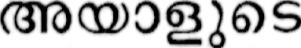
അയാളുടെ
